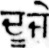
ਦੂਜੇ
